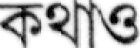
কথাও
